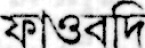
ফাওবদি
